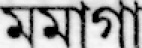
মমাগা
